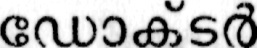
ഡോക്ടര്‍
